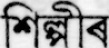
শিল্পীৰ
